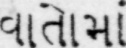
વાતોમાં
